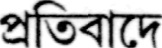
প্রতিবাদে
